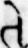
તે
